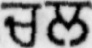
ਚਲ
